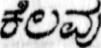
ಕೆಲವು
